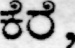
ಕೆರೆ,
